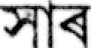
সাৰ
